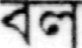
বল
